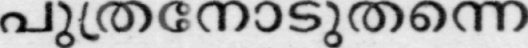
പുത്രനോടുതന്നെ
